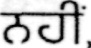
ਨਹੀਂ,
